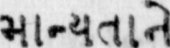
માન્યતાને
